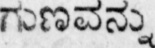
ಗುಣವನ್ನು
